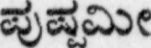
ಪುಷ್ಪಮೀ
